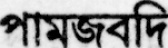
পামজবদি
